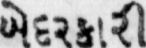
બેદરકારી
